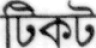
টিকট
